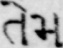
તેમ
